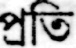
প্রতি
